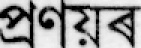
প্রণয়ৰ
